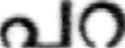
പറ
